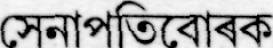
সেনাপতিবোৰক
